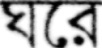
ঘরে
